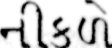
નીકળે
